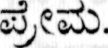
ಪ್ರೇಮ.
